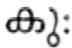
കു:
